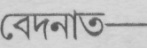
বেদনাত-
